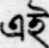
এই
